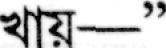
খায়-"
